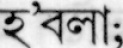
হ'বলা;
